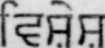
ਵਿਸ਼ੇਸ਼
